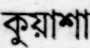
কুয়াশা
